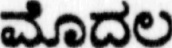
ಮೊದಲ
